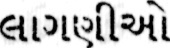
લાગણીઓ
